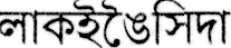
লাকইঙৈসিদা
